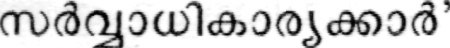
സര്‍വ്വാധികാര്യക്കാര്‍’
